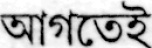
আগতেই
